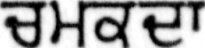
ਚਮਕਦਾ
